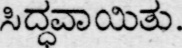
ಸಿದ್ಧವಾಯಿತು.
